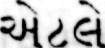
એટલે
